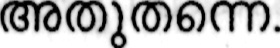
അതുതന്നെ.
